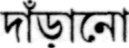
দাঁড়ানো
